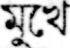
মুখে
